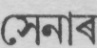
সেনাৰ
